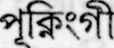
পূক্নিংগী
